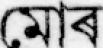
মোৰ
